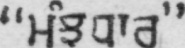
''ਮੰਝਧਾਰ''
